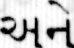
અને
